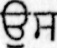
ਉਸ
